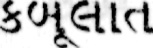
કબૂલાત
